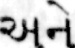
અને
